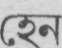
হেন
